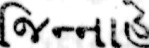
જિન્નાહે
